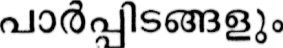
പാര്‍പ്പിടങ്ങളും
